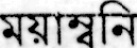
ময়াম্বনি
